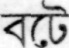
বটে
